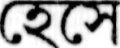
হেসে
